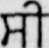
ਸੀ
